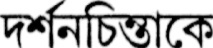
দর্শনচিন্তাকে
